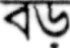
বড়
